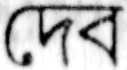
দেব
